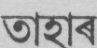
তাহাৰ
